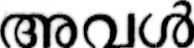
അവള്‍
